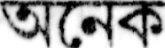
অনেক
